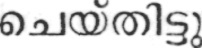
ചെയ്തിട്ടു
